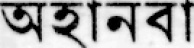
অহানবা
